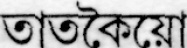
তাতকৈয়ো
